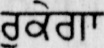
ਰੁਕੇਗਾ
